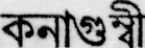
কনাগুম্বী
